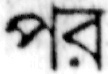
পর
